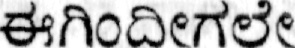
ಈಗಿಂದೀಗಲೇ
